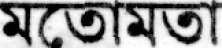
মতোমতা
